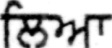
ਲਿਆ
